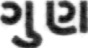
ગુણ
